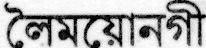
লৈময়োনগী
